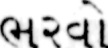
ભરવો
